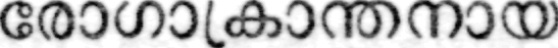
രോഗാക്രാന്തനായ
